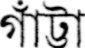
গাঁট্টা
